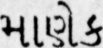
માણેક
